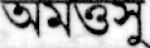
অমত্তসু
